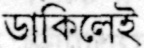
ডাকিলেই
